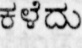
ಕಳೆದು
